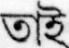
তাই
